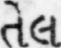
તેલ
